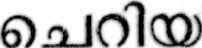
ചെറിയ
